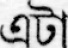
এটা
